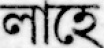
লাহে
